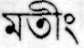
মতীং
